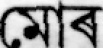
মোৰ
